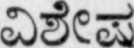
ವಿಶೇಷ
